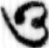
ও
